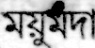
ময়ুমদা
